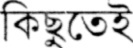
কিছুতেই
